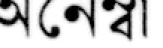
অনেম্বা
